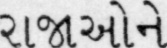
રાજાઓને
